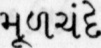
મૂળચંદે
